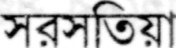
সরসতিয়া
